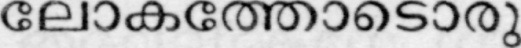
ലോകത്തോടൊരു
